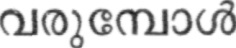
വരുമ്പോള്‍
